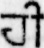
ਹੀ
